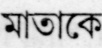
মাতাকে
